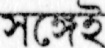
সঙ্গেই
